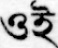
ওই
